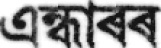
এন্ধাৰৰ
